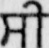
ਸੀ
